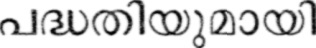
പദ്ധതിയുമായി
